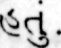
હતું.
